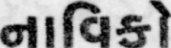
નાવિકો
